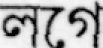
লগে
